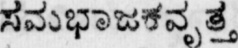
ಸಮಭಾಜಕವೃತ್ತ
